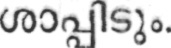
ശാപ്പിടും.
